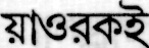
য়াওরকই
